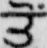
ਤੋਂ
